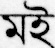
মই
